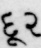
દૂર
